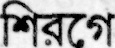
শিরগে
